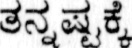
ತನ್ನಷ್ಟಕ್ಕೆ
